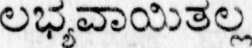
ಲಭ್ಯವಾಯಿತಲ್ಲ
